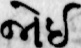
જોઈ
